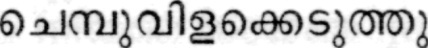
ചെമ്പുവിളക്കെടുത്തു
